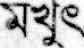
মখুৎ
